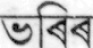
ভৰিৰ
